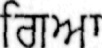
ਗਿਆ
